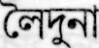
লৈদুনা
